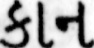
કાન
